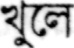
খুলে
